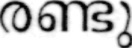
രണ്ടു
